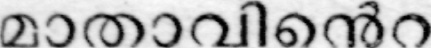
മാതാവിന്റെ
